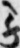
કે
